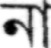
না
